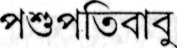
পশুপতিবাবু
